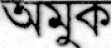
অমুক
